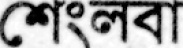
শেংলবা
